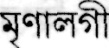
মৃণালগী
